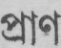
প্ৰাণ
